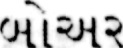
બોઅર
